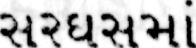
સરઘસમાં
